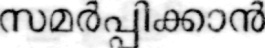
സമര്‍പ്പിക്കാന്‍
